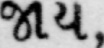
જાય,
